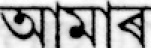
আমাৰ
